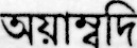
অয়াম্বদি
